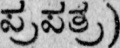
ಪ್ರಪತ್ರ)
